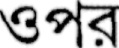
ওপর
